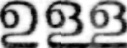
ഉള്ള
